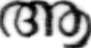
ആ
